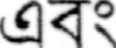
এবং
